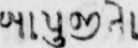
બાપુજીનો
